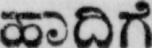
ಹಾದಿಗೆ
